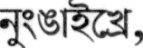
নুংঙাইখ্রে,
